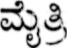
ಮೈತ್ರಿ
